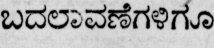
ಬದಲಾವಣೆಗಳಿಗೂ
